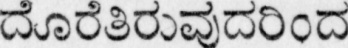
ದೊರೆತಿರುವುದರಿಂದ
